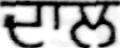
ਦਾਲ
